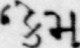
'કેમ
